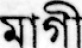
মাগী
